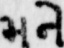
મને
